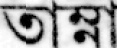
তাম্না
